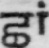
ਛਾਂ
